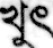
খুৎ
